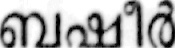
ബഷീര്‍
